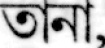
তানা,
